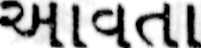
આવતા
